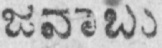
ಜವಾಬು
